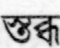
স্তব্ধ
